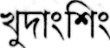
খুদাংশিং
